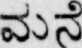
ಮನೆ
